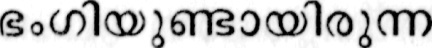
ഭംഗിയുണ്ടായിരുന്ന
